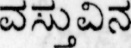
ವಸ್ತುವಿನ
